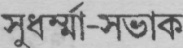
সুধৰ্ম্মা-সভাক
